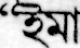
“ইমা
